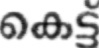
കെട്ട്
